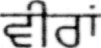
ਵੀਰਾਂ
